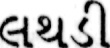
લથડી
